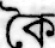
কৈ
